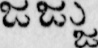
ಜಜ್ಜು
